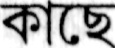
কাছে
